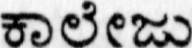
ಕಾಲೇಜು
